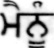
ਮੈਨੂੰ
